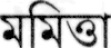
মমিত্তা
